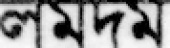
লমদম
